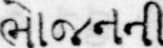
ભોજનની
